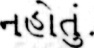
નહોતું.
